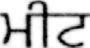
ਮੀਟ
